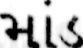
માંડ
